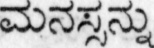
ಮನಸ್ಸನ್ನು
